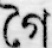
গৈ
